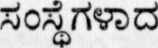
ಸಂಸ್ಥೆಗಳಾದ
